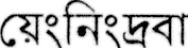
য়েংনিংদ্রবা
